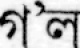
গ'ল
